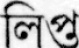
লিপ্ত
